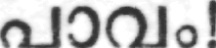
പാവം!
